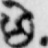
છે.
